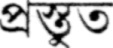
প্রস্তুত
